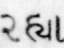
રહ્યા
